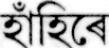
হাঁহিৰে
